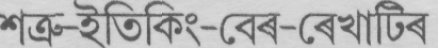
শত্ৰু-ইতিকিং-বেৰ-ৰেখাটিৰ
